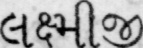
લક્ષ્મીજી
